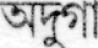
অদুগা
